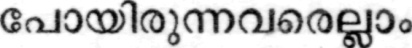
പോയിരുന്നവരെല്ലാം
